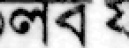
তলব
